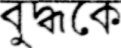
বুদ্ধকে
